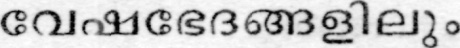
വേഷഭേദങ്ങളിലും
